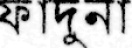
ফাদুনা
